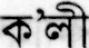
ক'লী
